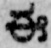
ಈ
